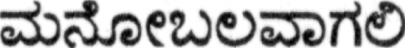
ಮನೋಬಲವಾಗಲಿ
